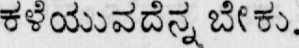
ಕಳೆಯುವದೆನ್ನಬೇಕು.
